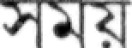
সময়
